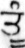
ਤੂੰ
